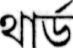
থার্ড
